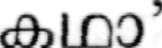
കഥാ'
